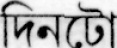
দিনটো
